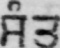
ਸੰਤ
